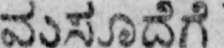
ಮಸೂದೆಗೆ
